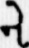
ને
